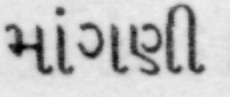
માંગણી
